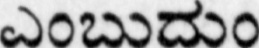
ಎಂಬುದುಂ
